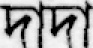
দাদা
